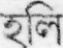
হলি
